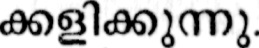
ക്കളിക്കുന്നു.
